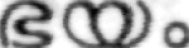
ഭയം
